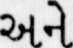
અને
